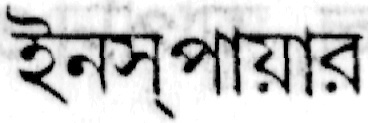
ইনস্‌পায়ার
